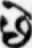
છે
